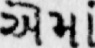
એમાં
